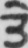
ਤੇ
